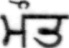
ਮੌਤ
